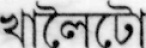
খালৈটো
